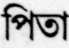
পিতা
